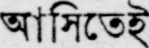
আসিতেই
